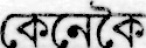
কেনেকৈ
